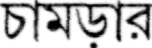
চামড়ার
